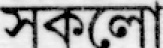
সকলো
